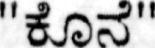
“ಕೊನೆ”
